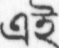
এই
